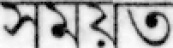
সময়ত
